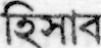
হিসাব
